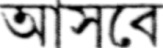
আসবে
